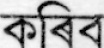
কৰিব
